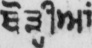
ਥੋੜ੍ਹੀਆਂ
